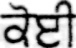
ਕੋਈ
